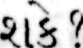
શકે?
